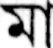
মা
